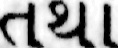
તથા
